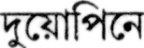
দুয়োপিনে
